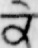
ਕੇ
